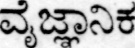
ವೈಜ್ಞಾನಿಕ
